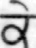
ਕੇ
